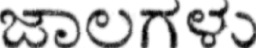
ಜಾಲಗಳು
